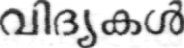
വിദ്യകള്‍
